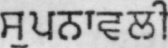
ਸੁਪਨਾਵਲੀ
